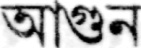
আগুন
